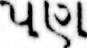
પણ
